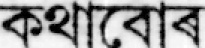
কথাবোৰ
